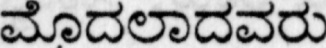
ಮೊದಲಾದವರು
